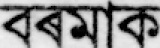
বৰমাক
